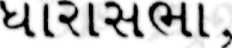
ધારાસભા
